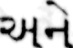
અને
